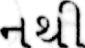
નથી
